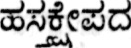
ಹಸ್ತಕ್ಷೇಪದ
